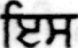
ਇਸ
